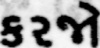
કરજો
